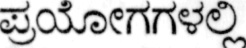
ಪ್ರಯೋಗಗಳಲ್ಲಿ
